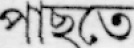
পাছতে
